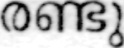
രണ്ടു
